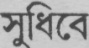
সুধিবে
